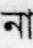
না
